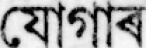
যোগাৰ
